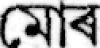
মোৰ
